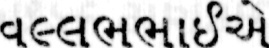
વલ્લભભાઈએ
